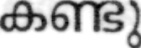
കണ്ടു
